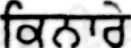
ਕਿਨਾਰੇ
